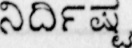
ನಿರ್ದಿಷ್ಟ
